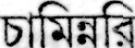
চামিন্নরি
